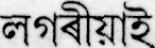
লগৰীয়াই
